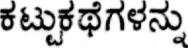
ಕಟ್ಟುಕಥೆಗಳನ್ನು
